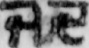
ਜਦ
